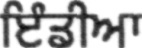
ਇੰਡੀਆ
